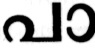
പാ
